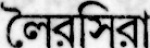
লৈরসিরা
